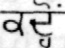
ਕਦ੍ਹੋਂ
